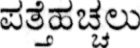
ಪತ್ತೆಹಚ್ಚಲು
